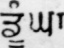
ਡੂੰਘਾ
